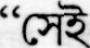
"সেই
